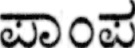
ಪಾಂಪ
